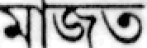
মাজত
